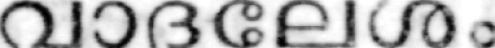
വാദലേശം
